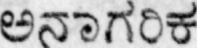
ಅನಾಗರಿಕ
